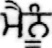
ਮੈਨੂੰ
